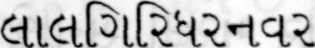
લાલગિરિધરનવર
